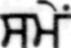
ਸਮੇਂ
